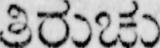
ತಿರುಚು
